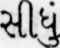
સીધું
